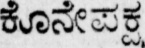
ಕೊನೇಪಕ್ಷ
